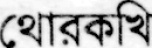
থোরকখি
